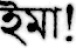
ইমা!
